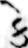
કે
